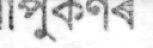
বাপুকণৰ
